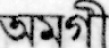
অমগী
